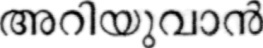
അറിയുവാന്‍
